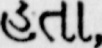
હતા,
